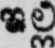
ಇಲ್ಲಿ
